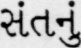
સંતનું
